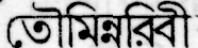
তৌমিন্নরিবী
